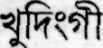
খুদিংগী
